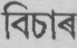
বিচাৰ
